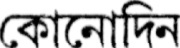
কোনোদিন
